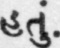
હતું.
